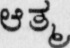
ಆತ್ಮ
